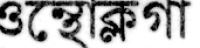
ওন্থোক্লগা
